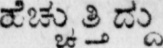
ಹೆಚ್ಚುತ್ತಿದ್ದು
